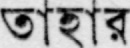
তাহার
